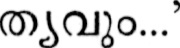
ത്യവും...’
